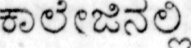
ಕಾಲೇಜಿನಲ್ಲಿ
